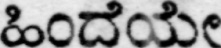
ಹಿಂದೆಯೇ
